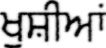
ਖੁਸ਼ੀਆਂ
